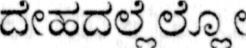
ದೇಹದಲ್ಲೆಲ್ಲೋ
